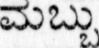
ಮಬ್ಬು
